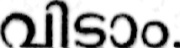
വിടാം.
